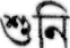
শুনি
